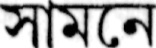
সামনে
